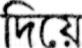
দিয়ে
